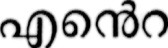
എന്റെ
